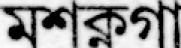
মশক্নগা
